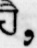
ਹੈ,
